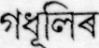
গধূলিৰ
